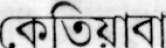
কেতিয়াবা
